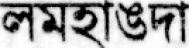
লমহাঙদা
